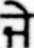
ਜੇ
